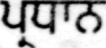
ਪ੍ਰਧਾਨ
